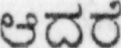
ಆದರೆ
